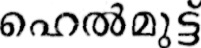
ഹെല്‍മുട്ട്
